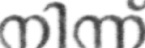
നിന്ന്
